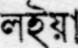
লইয়া
